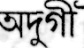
অদুগী
